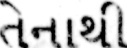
તેનાથી
